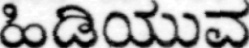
ಹಿಡಿಯುವ
